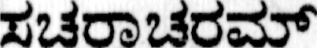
ಸಚರಾಚರಮ್
